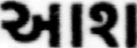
આશ
